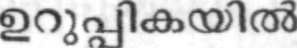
ഉറുപ്പികയില്‍
